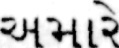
અમારે
